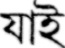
যাই
